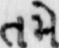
તમે
